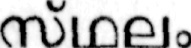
സ്ഥലം
